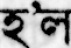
হ'ল
